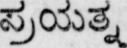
ಪ್ರಯತ್ನ
